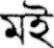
মই
